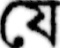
যে
